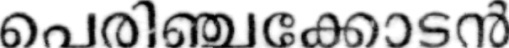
പെരിഞ്ചക്കോടന്‍
